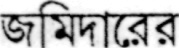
জমিদারের
